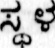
ಸ್ಥಳ
